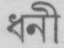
ধনী
